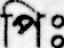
পিঃ
